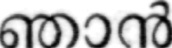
ഞാന്‍
